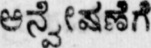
ಅನ್ವೇಷಣೆಗೆ
